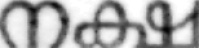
നക്ഷ
